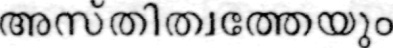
അസ്തിത്വത്തേയും
